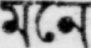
মনে
